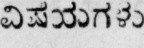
ವಿಷಯಗಳು
